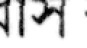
বাস
